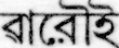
ৱারৌই
